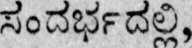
ಸಂದರ್ಭದಲ್ಲಿ,
